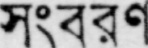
সংবরণ
